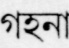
গহনা
